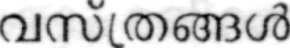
വസ്ത്രങ്ങള്‍
